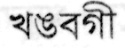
খঙবগী
